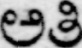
ಅತಿ
